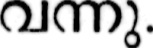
വന്നു.
